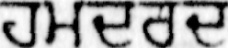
ਹਮਦਰਦੀ
